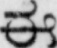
ಈ
